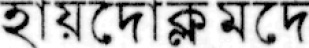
হায়দোক্লমদে
